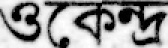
ওকেন্দ্র
